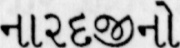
નારદજીનો
